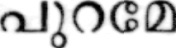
പുറമേ
